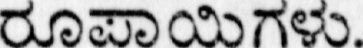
ರೂಪಾಯಿಗಳು.
